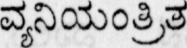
ವ್ಯನಿಯಂತ್ರಿತ
